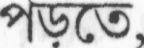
পড়তে,
